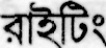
রাইটিং
